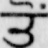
ਤੋਂ
